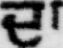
ਦਾ
